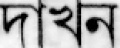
দাখন
